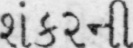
શંકરની
